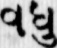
વધુ
